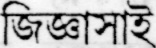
জিজ্ঞাসাই
